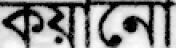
কয়ানো
